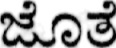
ಜೊತೆ
